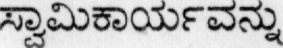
ಸ್ವಾಮಿಕಾರ್ಯವನ್ನು
